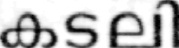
കടലി
